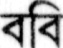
ববি
